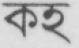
কহ
